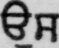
ਉਸ
